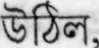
উঠিল,
